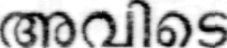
അവിടെ
